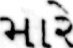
મારે
